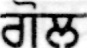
ਗੋਲ
